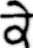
ਕੇ
